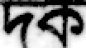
দক
